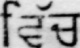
ਵਿੱਚ
